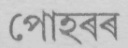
পোহৰৰ
